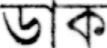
ডাক
